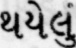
થયેલું
